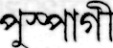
পুস্পাগী
